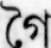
গৈ
